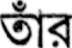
তাঁর
